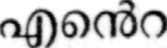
എന്റെ
